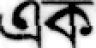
এক
